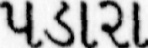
પડારા
